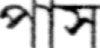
পাস
